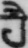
ਹੈ
